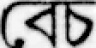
বেচ
